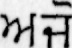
ਅਜੋ
